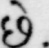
છે.
